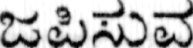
ಜಪಿಸುವ
